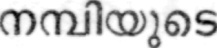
നമ്പിയുടെ
